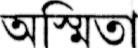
অস্মিতা
